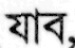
যাব,
